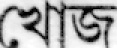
খোজ
